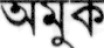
অমুক
